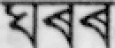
ঘৰৰ
